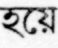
হয়ে
